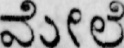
ಮೇಲೆ
